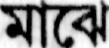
মাঝে
